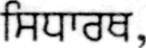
ਸਿਧਾਰਥ,
